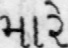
મારે
